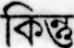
কিন্তু
